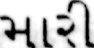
મારી
